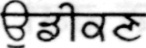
ਉਡੀਕਣ
